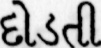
દોડતી
